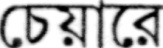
চেয়ারে
